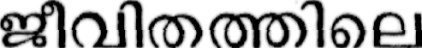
ജീവിതത്തിലെ
